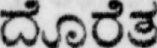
ದೊರೆತ
